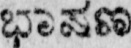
ಭಾಷಣ
